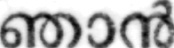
ഞാന്‍
